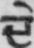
ਦੇ
